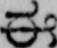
ಈ
